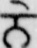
ਨੇ
